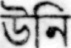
উনি
